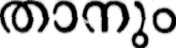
താനും
